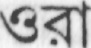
ওরা
